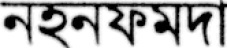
নহনফমদা
